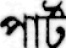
পার্ট
